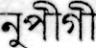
নুপীগী
